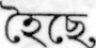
হৈছে,
